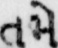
તમે
